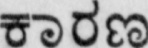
ಕಾರಣ
